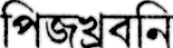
পিজখ্রবনি
